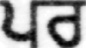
ਪਰ
